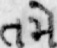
તમે
